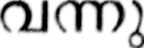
വന്നു
